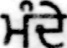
ਮੰਦੇ
